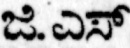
ಜಿ.ಎಸ್
